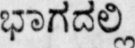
ಭಾಗದಲ್ಲಿ
